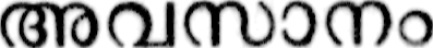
അവസാനം
